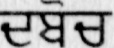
ਦਬੋਚ
